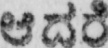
ಆದರೆ
